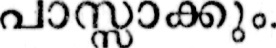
പാസ്സാക്കും.
